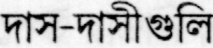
দাস-দাসীগুলি
